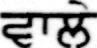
ਵਾਲੇ
